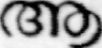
ആ
